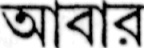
আবার
